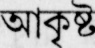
আকৃষ্ট
